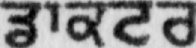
ਡਾਕਟਰ
